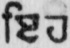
ਇਹ
